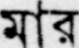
মার
